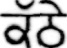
ਕੱਠੇ
